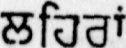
ਲਹਿਰਾਂ
